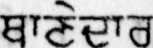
ਥਾਣੇਦਾਰ
